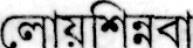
লোয়শিন্নবা
